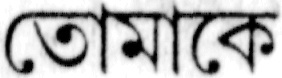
তোমাকে
